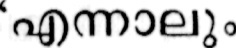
‘എന്നാലും
